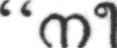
"നീ
